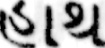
હાથ
